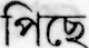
পিছে
